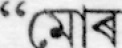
"মোৰ
